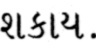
શકાય.
